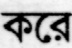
করে
